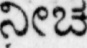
ನೀಚ
